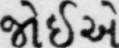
જોઈએ
